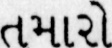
તમારો
